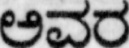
ಅವರ
